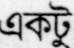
একটু
